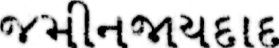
જમીનજાયદાદ
